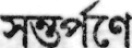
সন্তৰ্পণে
